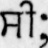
ਸੀ;
